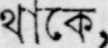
থাকে,
